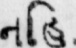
નહિ.
